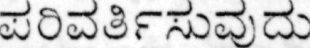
ಪರಿವರ್ತಿಸುವುದು
